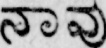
ನಾವು
